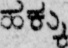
ಹಕ್ಕು
